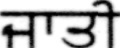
ਜਾਤੀ
